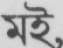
মই,
